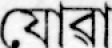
যোৱা
